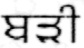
ਬੜੀ
